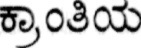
ಕ್ರಾಂತಿಯ
